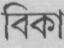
বিকা
